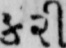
કરી
